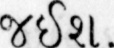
જઈશ.
